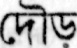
দৌড়
